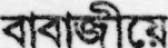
বাবাজীয়ে
